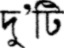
দু’টি
